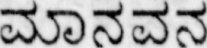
ಮಾನವನ
